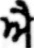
ਐ
